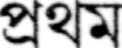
প্রথম
